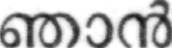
ഞാന്‍
